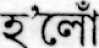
হ'লোঁ
